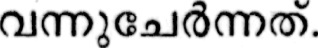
വന്നുചേര്‍ന്നത്.
